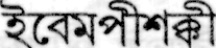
ইবেমপীশক্কী
